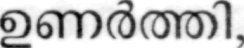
ഉണര്‍ത്തി,
